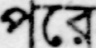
পরে
